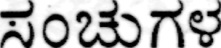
ಸಂಚುಗಳ
